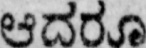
ಆದರೂ
